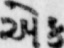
એક
